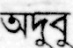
অদুবু
